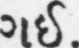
ગઈ.
